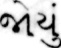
જોયું
